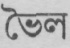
ভৈল
